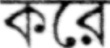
করে
